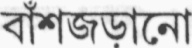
বাঁশজড়ানো
